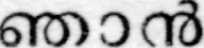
ഞാന്‍
